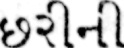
છરીની
